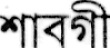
শাবগী
